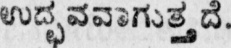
ಉದ್ಭವವಾಗುತ್ತದೆ.
